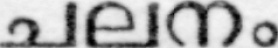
ചലനം
